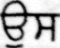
ਉਸ
